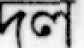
দল
